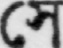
সে
